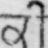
ਕੀ
